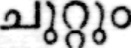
ചുറ്റും
